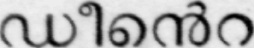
ഡീന്റെ
